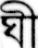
ঘী
